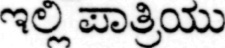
ಇಲ್ಲಿಪಾತ್ರಿಯು
